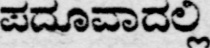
ಪದೂವಾದಲ್ಲಿ
